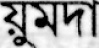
য়ুমদা
